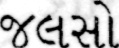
જલસો
